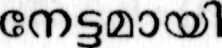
നേട്ടമായി
